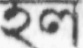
হল
